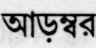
আড়ম্বর
